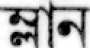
ম্লান
